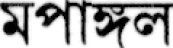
মপাঙ্গল
